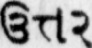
ઉત્તર
